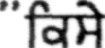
''ਕਿਸੇ
